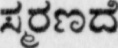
ಸ್ಮರಣದೆ
